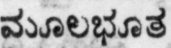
ಮೂಲಭೂತ
